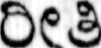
ರೀತಿ
